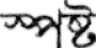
স্পষ্ট
